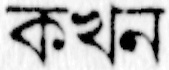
কখন
